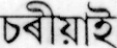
চৰীয়াই
